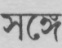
সঙ্গে
